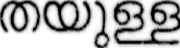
തയുള്ള
